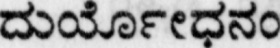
ದುರ್ಯೋಧನಂ
